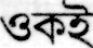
ওকই
